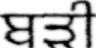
ਬੜੀ
